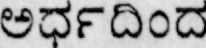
ಅರ್ಧದಿಂದ
